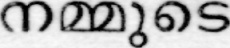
നമ്മുടെ
